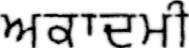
ਅਕਾਦਮੀ
